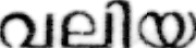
വലിയ
